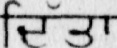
ਦਿੱਤਾ
